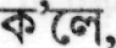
ক'লে,
